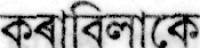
কৰাবিলাকে
